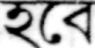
হবে
